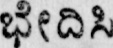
ಭೇದಿಸಿ
